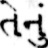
તેનું
